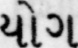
યોગ
